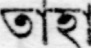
তাহা
